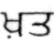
ਖ਼ਤ
